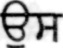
ਉਸ
